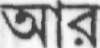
আর
